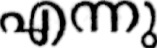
എന്നു
